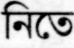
নিতে
